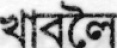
খাবলৈ
